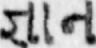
જ્ઞાન
